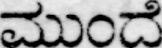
ಮು೦ದೆ
